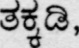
ತಕ್ಕಡಿ,
